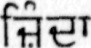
ਜ਼ਿੰਦਾ
